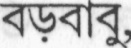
বড়বাবু,
